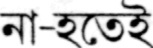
না-হতেই
